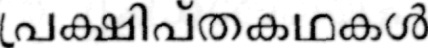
പ്രക്ഷിപ്തകഥകള്‍
